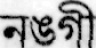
নঙগী
